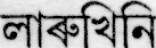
লাৰুখিনি
